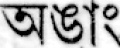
অঙাং
